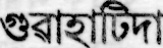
গুৱাহাটিদা
